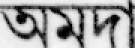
অমদা
